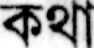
কথা
